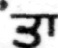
'ਤਾ
